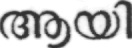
ആയി
